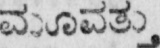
ಮೂವತ್ತು
